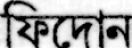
ফিদোন
